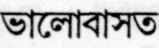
ভালোবাসত
